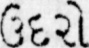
ઉંદરો
